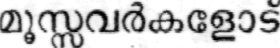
മൂസ്സവര്‍കളോട്
